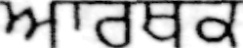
ਆਰਥਕ
